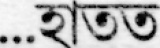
...হতত
